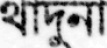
থাদুনা
